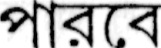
পারবে
